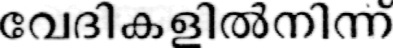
വേദികളില്‍നിന്ന്
